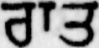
ਰਾਤ
